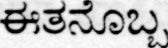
ಈತನೊಬ್ಬ
